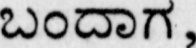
ಬಂದಾಗ,
